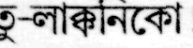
তু-লাক্কনিকো
